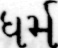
ધર્મ
